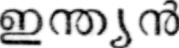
ഇന്ത്യന്‍
